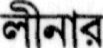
লীনার
